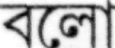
বলো
